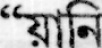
“য়ানি
